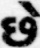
છે
